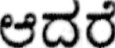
ಆದರೆ
